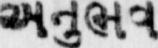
અનૂભવ
